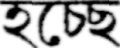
হচ্ছে
